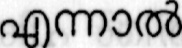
എന്നാല്‍
